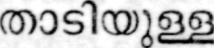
താടിയുള്ള
